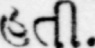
હતી.
